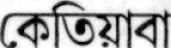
কেতিয়াবা
